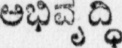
ಅಭಿವೃದ್ಧಿ
